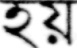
হয়
